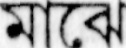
মাঝে
